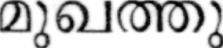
മുഖത്തു
